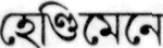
হেণ্ডিমেনে
